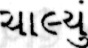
ચાલ્યું
